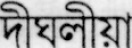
দীঘলীয়া
